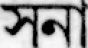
সনা
